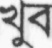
খুব
